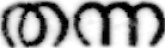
തന്ന
